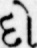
દો
